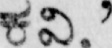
ಕವಿ.’
